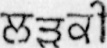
ਲੜਕੀ
